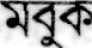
মবুক
